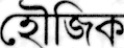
হৌজিক
